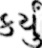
કર્યું
